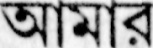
আমার
